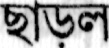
ছাড়ল
